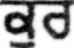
ਕੁਰ
